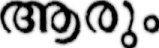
ആരും
